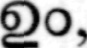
ഉം,
